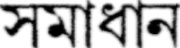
সমাধান
